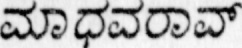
ಮಾಧವರಾವ್
